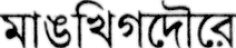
মাঙখিগদৌরে
